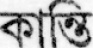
কান্তি
